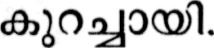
കുറച്ചായി.
